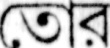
তোর
